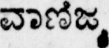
ವಾಣಿಜ್ಯ
